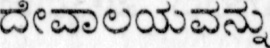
ದೇವಾಲಯವನ್ನು
